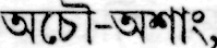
অচৌ-অশাং,
